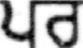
ਪਰ
